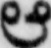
ಆ
